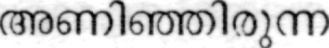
അണിഞ്ഞിരുന്ന
